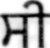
ਸੀ
